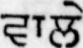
ਵਾਲੇ
